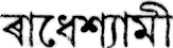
ৰাধেশ্যামী
